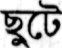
ছুটে
